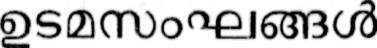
ഉടമസംഘങ്ങള്‍
